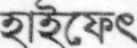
হাইফেৎ
